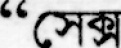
“সেক্স
